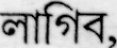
লাগিব,
